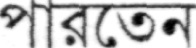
পারতেন
